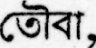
তৌবা,
